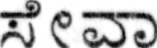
ಸೇವಾ
